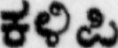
ಕಳಿಪಿ
